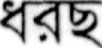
ধরছ
